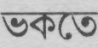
ভকতে
